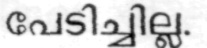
പേടിച്ചില്ല.
